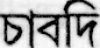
চাবদি
